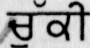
ਚੁੱਕੀ
